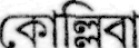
কোল্লিবা
